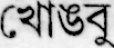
খোঙবু
